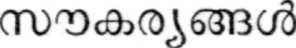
സൌകര്യങ്ങള്‍
